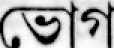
ভোগ
